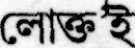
লোক্ত’ই
